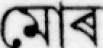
মোৰ
